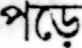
পড়ে
